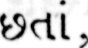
છતાં,
